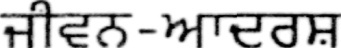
ਜੀਵਨ-ਆਦਰਸ਼
